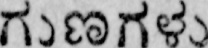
ಗುಣಗಳು
